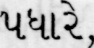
પધારે,
